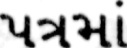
પત્રમાં
